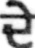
ਦੇ
